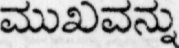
ಮುಖವನ್ನು
